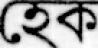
হেক
